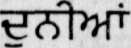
ਦੁਨੀਆਂ
